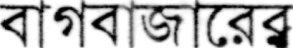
বাগবাজারের
